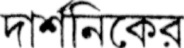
দার্শনিকের
